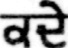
ਕਦੇ
